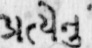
પ્રત્યેનું
